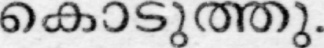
കൊടുത്തു.
